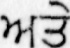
ਅਤੇ
